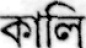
কালি
